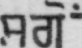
ਸਗੋਂ
